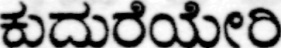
ಕುದುರೆಯೇರಿ
